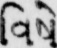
વિષે
